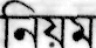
নিয়ম
